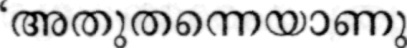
'അതുതന്നെയാണു
